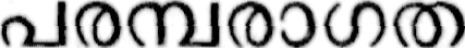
പരമ്പരാഗത
